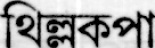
থিল্লকপা
